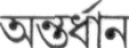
অন্তর্ধান
